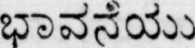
ಭಾವನೆಯು
